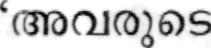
'അവരുടെ
